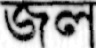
জল
